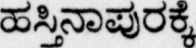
ಹಸ್ತಿನಾಪುರಕ್ಕೆ
